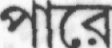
পারে
